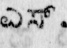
ಎಸ್.
